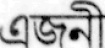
এজনী
